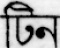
টিন
